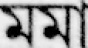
মমা
